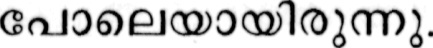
പോലെയായിരുന്നു.
